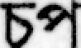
চপ
